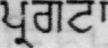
ਪ੍ਰਗਟਾ
